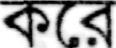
করে
